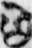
છે
